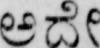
ಅದೇ
